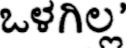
ಒಳಗಿಲ್ಲ'
